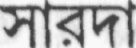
সারদা
